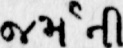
જર્મની
